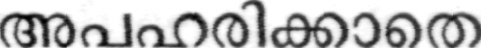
അപഹരിക്കാതെ
